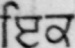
ਇਕ
